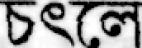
চৎলে
